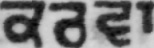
ਕਰਵਾ
